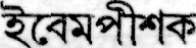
ইবেমপীশক
